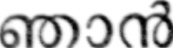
ഞാന്‍
